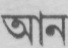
আন
